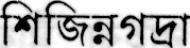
শিজিন্নগদ্রা
